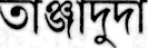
তাঞ্জাদুদা
